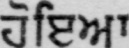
ਹੋਇਆ
